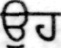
ਉਹ
